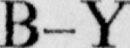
B-Y
